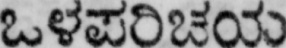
ಒಳಪರಿಚಯ
